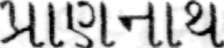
પ્રાણનાથ
